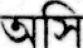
অসি
